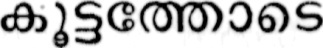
കൂട്ടത്തോടെ
